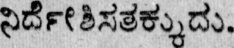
ನಿರ್ದೇಶಿಸತಕ್ಕುದು.
